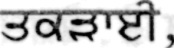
ਤਕੜਾਈ,
